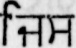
ਜਿਸ
